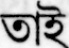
তাই
